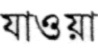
যাওয়া
